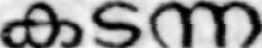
കടന്ന
